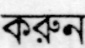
করুন
